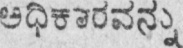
ಅಧಿಕಾರವನ್ನು
